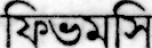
ফিভমসি
